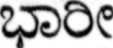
ಭಾರೀ
